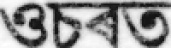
ওচৰত
